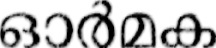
ഓര്‍മക
